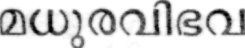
മധുരവിഭവ
